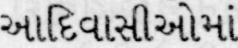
આદિવાસીઓમાં
